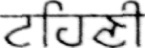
ਟਹਿਣੀ
